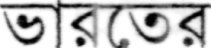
ভারতের
